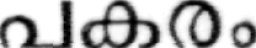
പകരം
